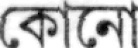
কোনো
